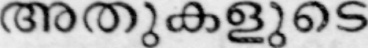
അതുകളുടെ
